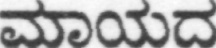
ಮಾಯದ
